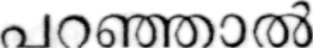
പറഞ്ഞാല്‍
